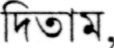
দিতাম,
